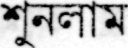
শুনলাম
